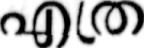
എത്ര
